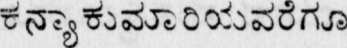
ಕನ್ಯಾಕುಮಾರಿಯವರೆಗೂ
